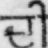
ਦੀ
